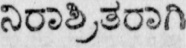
ನಿರಾಶ್ರಿತರಾಗಿ
